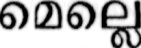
മെല്ലെ
